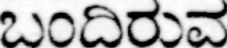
ಬಂದಿರುವ
